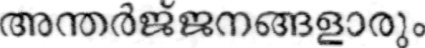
അന്തര്‍ജ്ജനങ്ങളാരും
